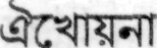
ঐখোয়না
